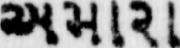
અમારા
